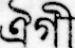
ঐগী
